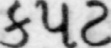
કપટ
